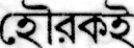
হৌরকই
